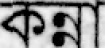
কন্না
